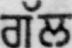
ਗੱਲ
